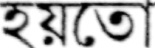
হয়তো
